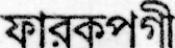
ফারকপগী
